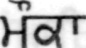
ਮੌਕਾ
